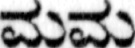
ಮಮ
